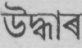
উদ্ধাৰ
